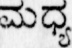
ಮಧ್ಯ
